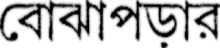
বোঝাপড়ার
